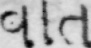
વાત
